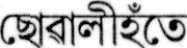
ছোৱালীহঁতে
